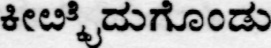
ಕೀೞ್ಕೈದುಗೊಂಡು
